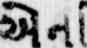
એનાં
